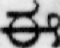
ಈ
